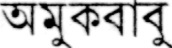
অমুকবাবু
